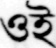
ওই
